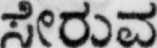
ಸೇರುವ
